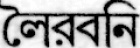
লৈরবনি
